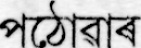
পঠোৱাৰ
